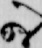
જે
